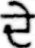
ਦੇ
